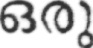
ഒരു
